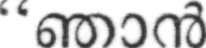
"ഞാന്‍
